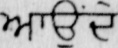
ਆਉਂਦੇ
